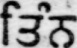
ਤਿੰਨ
